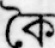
কৈ
